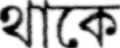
থাকে
